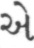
એ
